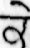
ਕੇ
